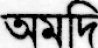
অমদি
